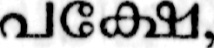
പക്ഷേ,
